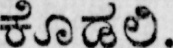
ಕೊಡಲಿ.
